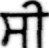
ਸੀ
